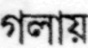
গলায়
